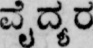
ವೈದ್ಯರ
